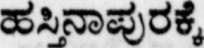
ಹಸ್ತಿನಾಪುರಕ್ಕೆ
